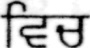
ਵਿਚ
